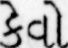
કેવો
